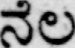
ನೆಲ
